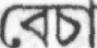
বেচা
